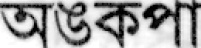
অঙকপা
